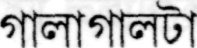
গালাগালটা
